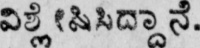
ವಿಶ್ಲೇಷಿಸಿದ್ದಾನೆ.
